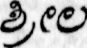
ಶ್ರೀಲ
